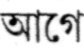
আগে
